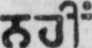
ਨਹੀਂ
